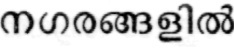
നഗരങ്ങളില്‍
